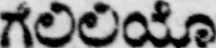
ಗೆಲಿಲಿಯೊ
